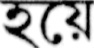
হয়ে
